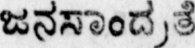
ಜನಸಾಂದ್ರತೆ
